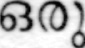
ഒരു
